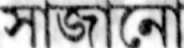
সাজানো
